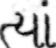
ત્યાં
